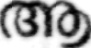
ആ
